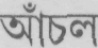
আঁচল
